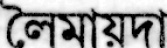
লৈমায়দা
